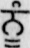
ਨੂੰ
